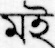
মই
